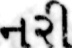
નરી
